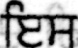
ਇਸ
